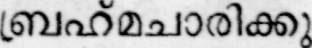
ബ്രഹ്മചാരിക്കു
